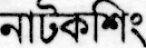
নাটকশিং
